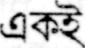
একই
